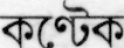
কণ্টেক
